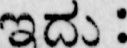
ಇದು:
